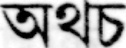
অথচ
